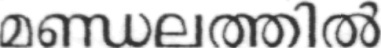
മണ്ഡലത്തില്‍
